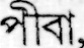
পীবা,
